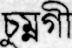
চুম্নগী
